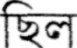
ছিল
